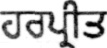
ਹਰਪ੍ਰੀਤ
